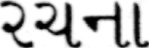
રચના
